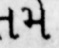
તમે
